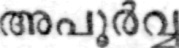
അപൂര്‍വ്വ
